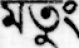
মতুং
